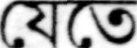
যেতে
